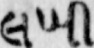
લખી
